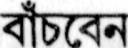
বাঁচবেন
